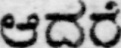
ಆದರೆ
